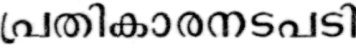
പ്രതികാരനടപടി
